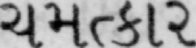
ચમત્કાર
